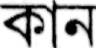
কান
